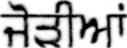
ਜੋੜੀਆਂ
